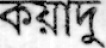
কয়াদু
